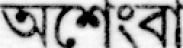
অশেংবা
